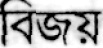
বিজয়
